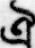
ঐ
